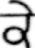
ਕੇ
